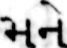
મને
